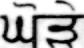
ਘੋੜੇ
